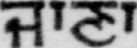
ਜਾਣਾ
